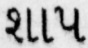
શાપ
